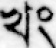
খং
